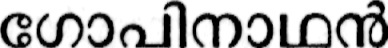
ഗോപിനാഥന്‍
